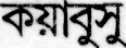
কয়াবুসু
